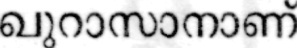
ഖുറാസാനാണ്
